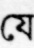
যে
